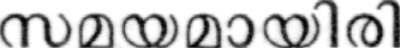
സമയമായിരി
